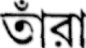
তাঁরা
